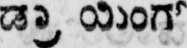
ಡ್ರಾಯಿಂಗ್
